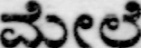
ಮೇಲೆ
